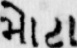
મોટા
